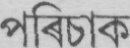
পৰিচাক
